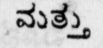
ಮತ್ತು
